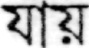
যায়
